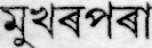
মুখৰপৰা
